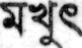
মখুৎ
